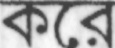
করে
